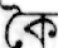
কৈ
